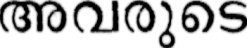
അവരുടെ
